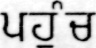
ਪਹੁੰਚ
